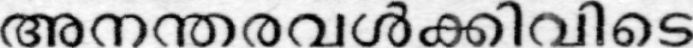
അനന്തരവള്‍ക്കിവിടെ
